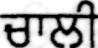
ਚਾਲੀ
